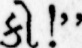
કો!"
